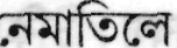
নেমাতিলে
